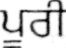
ਪੂਰੀ
